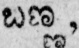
ಬಣ್ಣ,
